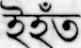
ইহঁত
